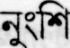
নুংশি
